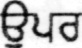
ਉਪਰ
